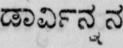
ಡಾರ್ವಿನ್ನನ
